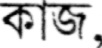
কাজ,
